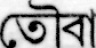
তৌবা
